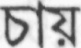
চায়
